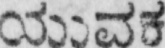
ಯುವಕ
